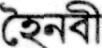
হৈনবী
